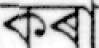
কৰা
